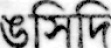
ঙসিদি
